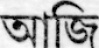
আজি
